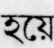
হয়ে
